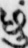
છું
